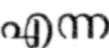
എന്ന
